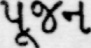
પૂજન
